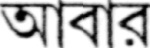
আবার
